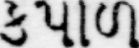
કપાળ
